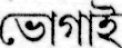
ভোগাই
